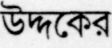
উদ্দকের
